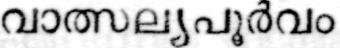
വാത്സല്യപൂര്‍വം
